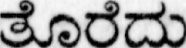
ತೊರೆದು
